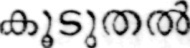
കൂടുതല്‍
